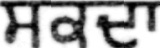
ਸਕਦਾ
